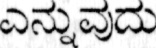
ಎನ್ನುವುದು
